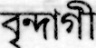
বৃন্দাগী
